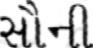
સૌની
